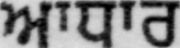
ਆਧਾਰ
